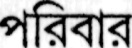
পরিবার
